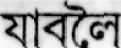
যাবলৈ
